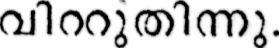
വിററുതിന്നു.
